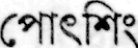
পোৎশিং
